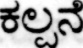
ಕಲ್ಪನೆ
